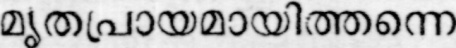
മൃതപ്രായമായിത്തന്നെ
